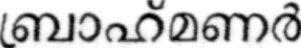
ബ്രാഹ്മണര്‍
